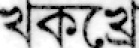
খকখ্রে
